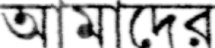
আমাদের
